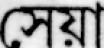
সেয়া
